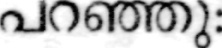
പറഞ്ഞു:
